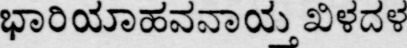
ಭಾರಿಯಾಹವವಾಯ್ತಖಿಲದಳ
